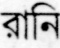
রানি
